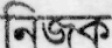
নিজক
